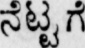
ನೆಟ್ಟಗೆ
